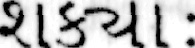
શક્યાઃ
